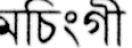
মচিংগী
